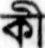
কী
